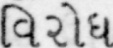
વિરોધ
